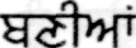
ਬਣੀਆਂ
